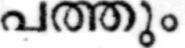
പത്തും
